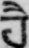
ਹੈ
